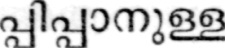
പ്പിപ്പാനുള്ള
